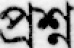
প্রশ্ন
